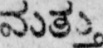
ಮತ್ತು
